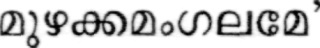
മുഴക്കമംഗലമേ’
